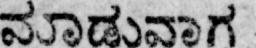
ಮಾಡುವಾಗ
